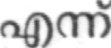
എന്ന്
